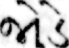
જોડે
